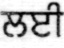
ਲਈ
